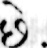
છે.
